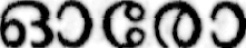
ഓരോ
